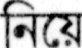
নিয়ে
